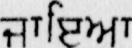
ਜਾਇਆ
